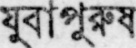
যুবাপুরুষ
